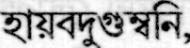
হায়বদুগুম্বনি,
